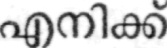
എനിക്ക്
